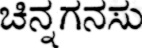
ಚಿನ್ನಗನಸು
